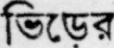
ভিড়ের
